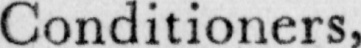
Conditioners,
